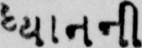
ધ્યાની
